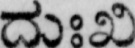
ದುಃಖಿ
